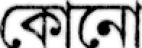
কোনো
